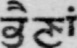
ਭੈਣਾਂ
